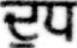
ਦੁਧ
